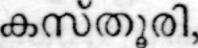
കസ്തൂരി,
